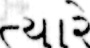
ત્યારે
